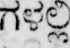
ಗಳಲ್ಲಿ
